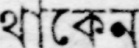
থাকেন
